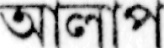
আলাপ
